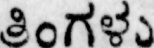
ತಿಂಗಳು
